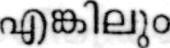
എങ്കിലും
